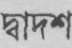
দ্বাদশ
